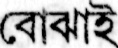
বোঝাই
